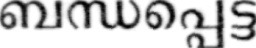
ബന്ധപ്പെട്ട
